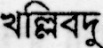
খল্লিবদু
